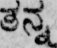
ತನ್ನ
